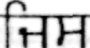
ਜਿਸ
